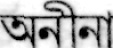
অনীনা
